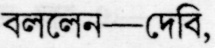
বললেন–দেবি,
